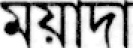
ময়াদা
